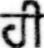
ਹੀ
